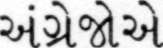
અંગ્રેજોએ
